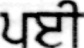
ਪਈ
